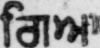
ਗਿਆ
